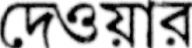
দেওয়ার
